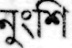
নুংশি
